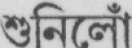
শুনিলোঁ
